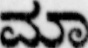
ಮಾ
